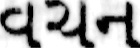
વચન
